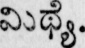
ಮಿಥ್ಯೆ.
